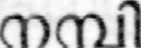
നമ്പി
